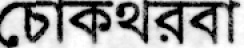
চোকথরবা
